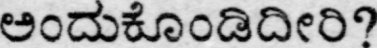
ಅಂದುಕೊಂಡಿದೀರಿ?
